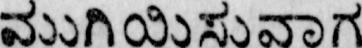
ಮುಗಿಯಿಸುವಾಗ
